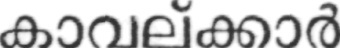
കാവല്ക്കാര്‍
